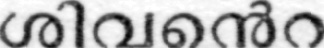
ശിവന്റെ
